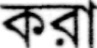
করা
